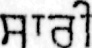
ਸਾਰੀ
